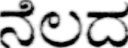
ನೆಲದ
